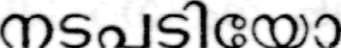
നടപടിയോ
